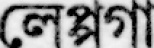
লেপ্পগা
